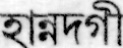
হান্নদগী
